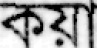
কয়া
